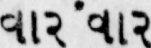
વારંવાર
